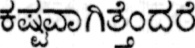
ಕಷ್ಟವಾಗಿತ್ತೆಂದರೆ
